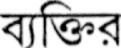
ব্যক্তির
